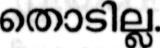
തൊടില്ല.
